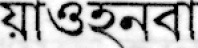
য়াওহনবা
